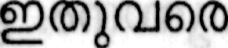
ഇതുവരെ
